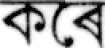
কৰে
